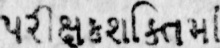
પરીક્ષાશક્તિમાં
